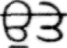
ਉਤੇ
